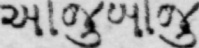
આજુબાજુ
